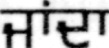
ਜਾਂਦਾ
